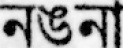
নঙনা
